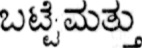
ಬಟ್ಟೆಮತ್ತು
